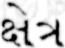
ક્ષેત્ર
